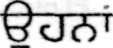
ਉਹਨਾਂ
